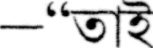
–“তাই
